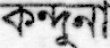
কন্দুনা
